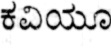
ಕವಿಯೂ
